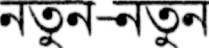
নতুন-নতুন
